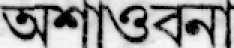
অশাওবনা
